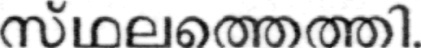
സ്ഥലത്തെത്തി.
